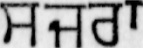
ਸਜਰਾ
